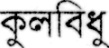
কুলবিধু
